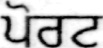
ਪੋਰਟ
